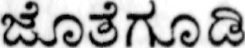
ಜೊತೆಗೂಡಿ
